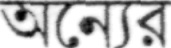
অন্যের
